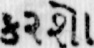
કરશો
